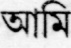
আমি
